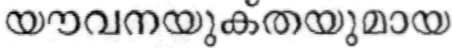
യൌവനയുക്തയുമായ
